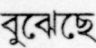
বুঝেছে
